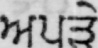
ਅਪੜੇ
